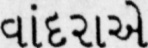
વાંદરાએ
